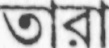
তারা
